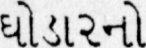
ઘોડારનો
